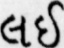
લઈ
